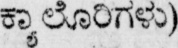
ಕ್ಯಾಲೊರಿಗಳು)
